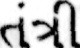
તંત્રી
